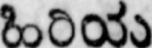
ಹಿರಿಯ
